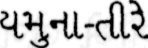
યમુના-તીરે
